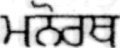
ਮਨੋਰਥ
